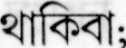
থাকিবা;
